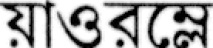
য়াওরম্লে
